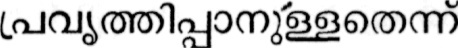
പ്രവൃത്തിപ്പാനുള്ളതെന്ന്
